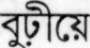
বুঢ়ীয়ে
